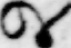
જ
